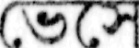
ভেসে
